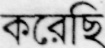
করেছি
